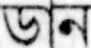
ডান
